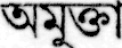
অমুক্তা
